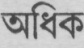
অধিক
